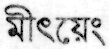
মীৎয়েং
